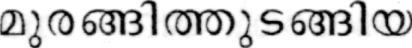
മുരങ്ങിത്തുടങ്ങിയ
